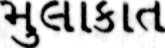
મુલાકાત
